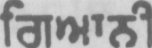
ਗਿਆਨੀ
